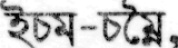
ইচম-চম্নৈ,
